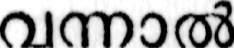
വന്നാല്‍
